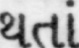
થતાં
